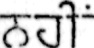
ਨਹੀਂ
